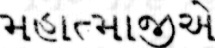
મહાત્માજીએ
